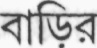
বাড়ির
